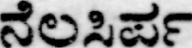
ನೆಲಸಿರ್ಪ
